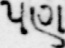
પણ
